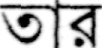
তার
